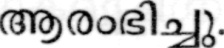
ആരംഭിച്ചു.
